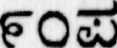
೯೦ಪ
